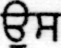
ਉਸ
